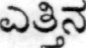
ಎತ್ತಿನ
